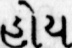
હોય
